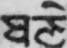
ਬਣੇ
